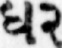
ઘર
